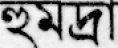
হুমদ্রা
